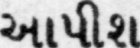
આપીશ
